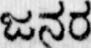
ಜನರ
